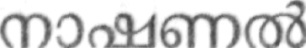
നാഷണല്‍
